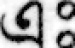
এঃ
